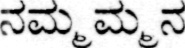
ನಮ್ಮಮ್ಮನ
